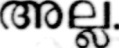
അല്ല.
